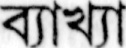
ব্যাখ্যা
